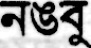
নঙবু
